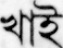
খাই
